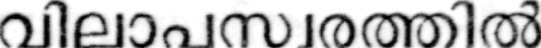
വിലാപസ്വരത്തില്‍
